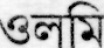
ওলমি
